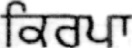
ਕਿਰਪਾ
